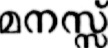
മനസ്സ്
